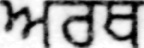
ਅਰਥ
